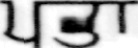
ਪਤਾ
